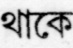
থাকে
